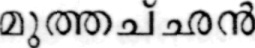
മുത്തച്ഛന്‍
